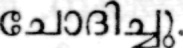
ചോദിച്ചു.
